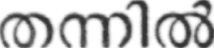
തന്നില്‍
